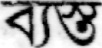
ব্যস্ত
